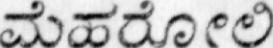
ಮೆಹರೋಲಿ
